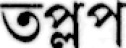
তপ্লপ
